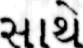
સાથે
